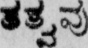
ತತ್ವವು
